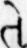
તે
